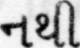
નથી
